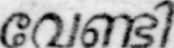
വേണ്ടി
